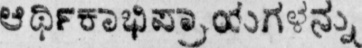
ಆರ್ಥಿಕಾಭಿಪ್ರಾಯಗಳನ್ನು
